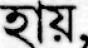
হায়,
